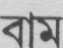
বাম
